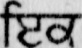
ਇਕ
